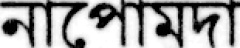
নাপোমদা
